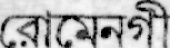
রোমেনগী
